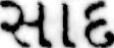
સાદ
